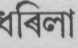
ধৰিলা
